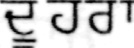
ਦੂਹਰਾ
